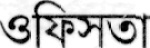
ওফিসতা
